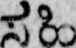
ಸಹಿ
